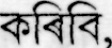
কৰিবি,
